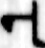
ન
